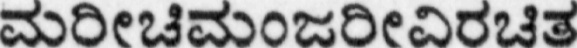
ಮರೀಚಿಮಂಜರೀವಿರಚಿತ
